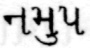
નમુપ
